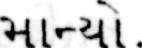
માન્યો.
